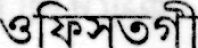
ওফিসতগী
